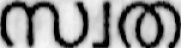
സ്വത
